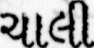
ચાલી
